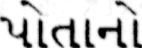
પોતાનો
